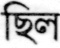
ছিল
